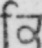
ਕਿ
